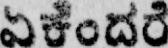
ಏಕೆಂದರೆ
